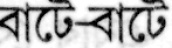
বাটে-বাটে
